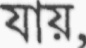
যায়,
